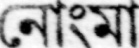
নোংমা
